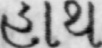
હાથ
